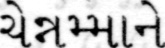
ચેન્નમ્માને
